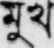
মুখ
